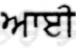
ਆਈ
